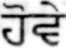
ਹੋਵੇ
